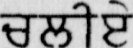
ਚਲੀਏ
